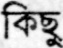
কিছু
